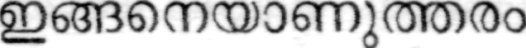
ഇങ്ങനെയാണുത്തരം
